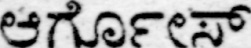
ಆರ್ಗೋಸ್
